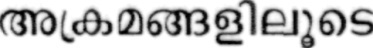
അക്രമങ്ങളിലൂടെ
